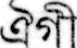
ঐগী
